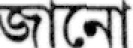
জানো
